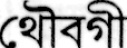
থৌবগী
